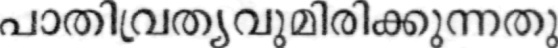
പാതിവ്രത്യവുമിരിക്കുന്നതു
